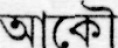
আকৌ
